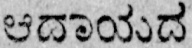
ಆದಾಯದ
